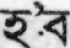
হ'ব
